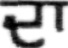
ਦਾ
